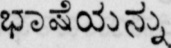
ಭಾಷೆಯನ್ನು
